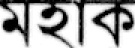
মহাক
